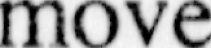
move
